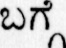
ಬಗ್ಗೆ
